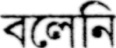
বলেনি
